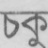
চকু
